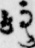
કરું
